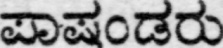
ಪಾಷಂಡರು
